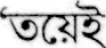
'তয়েই
